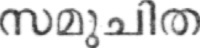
സമുചിത
